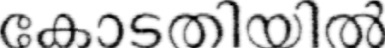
കോടതിയില്‍
